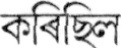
কৰিছিল
